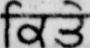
ਕਿਤੇ
